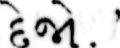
દેજો.'
